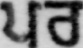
ਪਰ
